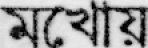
মখোয়
